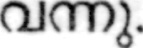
വന്നു.
